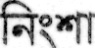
নিংশা
